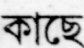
কাছে
